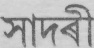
সাদৰী
